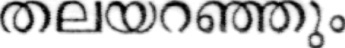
തലയറഞ്ഞും
